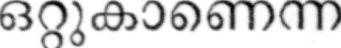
ഒറ്റുകാണെന്ന
